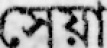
সেয়া
